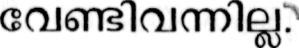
വേണ്ടിവന്നില്ല.
